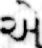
એ
